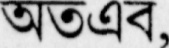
অতএব,
